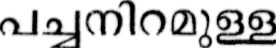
പച്ചനിറമുള്ള
